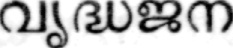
വൃദ്ധജന
